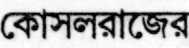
কোসলরাজের
